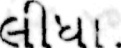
લીધા.
